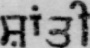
ਸ਼ਾਂਤੀ
